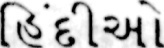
હિંદીઓ
